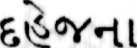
દહેજના
